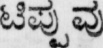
ಟಿಪ್ಪುವು
